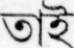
তাই
